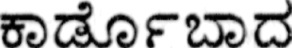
ಕಾರ್ಡೊಬಾದ
